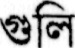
গুলি
